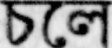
চলে
